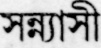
সন্ন্যাসী
